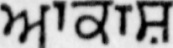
ਆਕਾਸ਼
